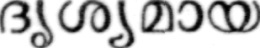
ദൃശ്യമായ
